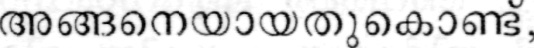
അങ്ങനെയായതുകൊണ്ട്,
